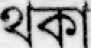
থকা
